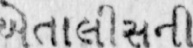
બેતાલીસની
